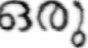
ഒരു
